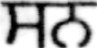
ਸਨ
